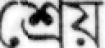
শ্ৰেয়
